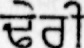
ਢੇਰੀ
